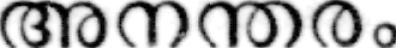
അനന്തരം
